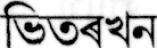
ভিতৰখন
